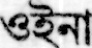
ওইনা
